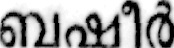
ബഷീര്‍
